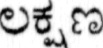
ಲಕ್ಷಣ
